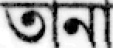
তানা
